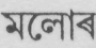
মলোৰ
